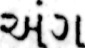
અંગ
